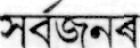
সর্বজনৰ
